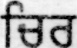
ਚਿਰ
